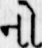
નો
